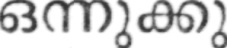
ഒന്നുക്കു
